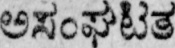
ಅಸಂಘಟಿತ
